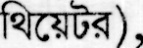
থিয়েটর),
